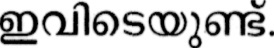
ഇവിടെയുണ്ട്.
